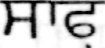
ਸਾਫ਼
